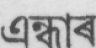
এন্ধাৰ
